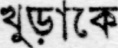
খুড়াকে
